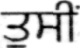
ਤੁਸੀਂ
